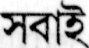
সবাই
